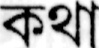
কথা
